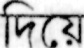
দিয়ে
